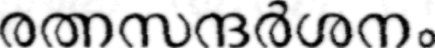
രത്നസന്ദര്‍ശനം
